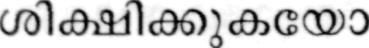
ശിക്ഷിക്കുകയോ
